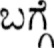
ಬಗ್ಗೆ
